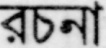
রচনা
